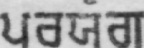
ਪਰਯੋਗ
